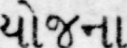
યોજના
